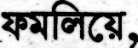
ফমলিয়ে,
